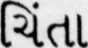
ચિંતા
